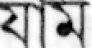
যাম
